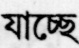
যাচ্ছে
